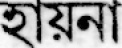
হায়না
